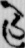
હે
